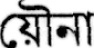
য়ৌনা
